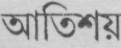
আতিশয়
